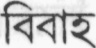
বিবাহ
